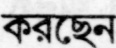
করছেন
